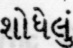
શોધેલું
